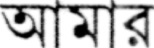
আমার
